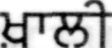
ਖ਼ਾਲੀ
